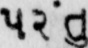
પરંતુ
